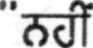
''ਨਹੀਂ
